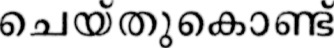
ചെയ്തുകൊണ്ട്
